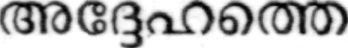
അദ്ദേഹത്തെ
